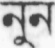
নুন
